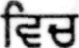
ਵਿਚ
